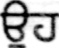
ਉਹ
